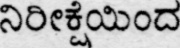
ನಿರೀಕ್ಷೆಯಿಂದ
